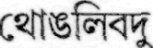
থোঙলিবদু
